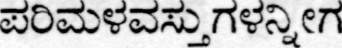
ಪರಿಮಳವಸ್ತುಗಳನ್ನೀಗ
